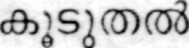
കൂടുതല്‍
